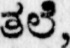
ತಲೆ,
